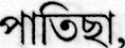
পাতিছা,
